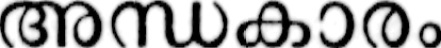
അന്ധകാരം
